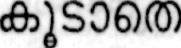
കൂടാതെ
